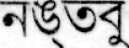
নঙতবু
